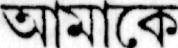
আমাকে
